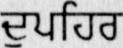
ਦੁਪਹਿਰ
